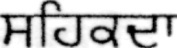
ਸਹਿਕਦਾ
